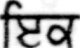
ਇਕ
